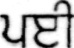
ਪਈ
